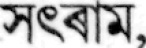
সৎৰাম,
